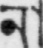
না
